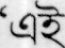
'এই
